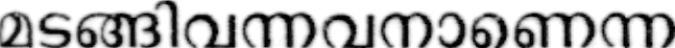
മടങ്ങിവന്നവനാണെന്ന
